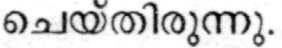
ചെയ്തിരുന്നു.
